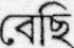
বেছি
